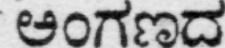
ಅಂಗಣದ
